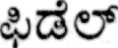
ಫಿಡೆಲ್
